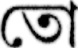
তো
